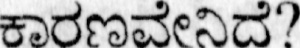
ಕಾರಣವೇನಿದೆ?
